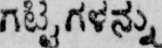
ಗಟ್ಟಿಗಳನ್ನು
